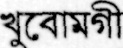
খুবোমগী
